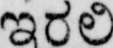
ಇರಲಿ
